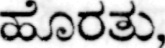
ಹೊರತು,
